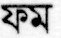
ফম
